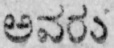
ಅವರು
